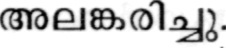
അലങ്കരിച്ചു.
